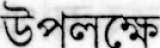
উপলক্ষে
